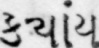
ક્યાંય
